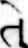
તે
